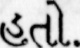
હતો.
